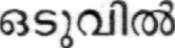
ഒടുവില്‍
